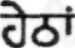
ਹੇਠਾਂ
